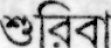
শুরিবা
